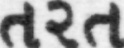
તરત
